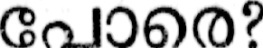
പോരെ?
